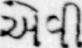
એવી
